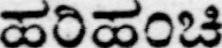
ಹರಿಹಂಚಿ
